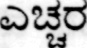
ಎಚ್ಚರ
